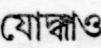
যোদ্ধাও
